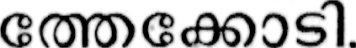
ത്തേക്കോടി.
